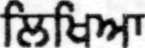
ਲਿਖਿਆ
